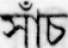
সাঁচ
